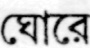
ঘোরে
